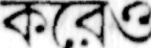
করেও
